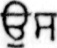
ਉਸ
